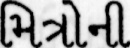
મિત્રોની
